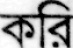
করি
